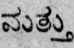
ಮತ್ತು
